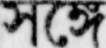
সঙ্গে
